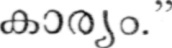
കാര്യം."
